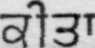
ਕੀਤਾ
